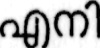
എനി
